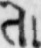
તો
